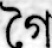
গৈ
